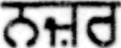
ਨਜ਼ਰ
